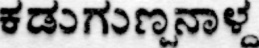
ಕಡುಗುಣ್ಪನಾಳ್ದ
